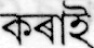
কৰাই
